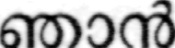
ഞാന്‍
